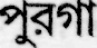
পুরগা
